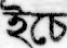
ইচে
